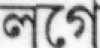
লগে
